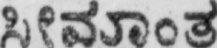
ಸೀಮಾಂತ
